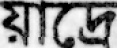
য়াদ্রে
